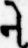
ને
